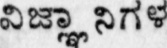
ವಿಜ್ಞಾನಿಗಳ
